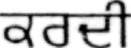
ਕਰਦੀ
